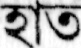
হাত
